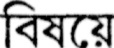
বিষয়ে
